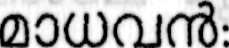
മാധവന്‍:
